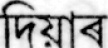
দিয়াৰ
